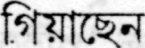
গিয়াছেন
